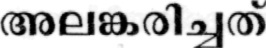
അലങ്കരിച്ചത്
